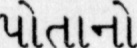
પોતાનો
